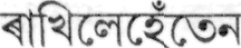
ৰাখিলেহেঁতেন
